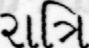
રાત્રિ
